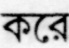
করে
